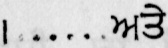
।...........ਅਤੇ
